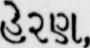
હેરણ,
